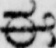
ಈ
